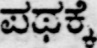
ಪಥಕ್ಕೆ
